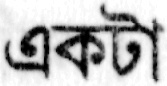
একটা
